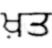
ਖ਼ਤ
